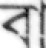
বা
